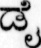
ಡೈ
